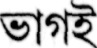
ভাগই
